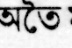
অতৈ
